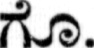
ಗೊ.
